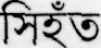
সিহঁত
